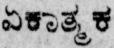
ಏಕಾತ್ಮಕ
